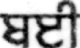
ਬਈ
